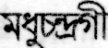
মধুচন্দ্রগী
